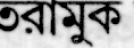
তরামুক
